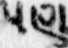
પણ
